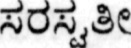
ಸರಸ್ವತೀ
